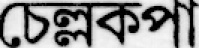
চেল্লকপা
